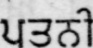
ਪਤਨੀ
